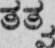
ತತ್ವ
